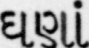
ઘણાં
